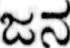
ಜನ
